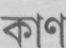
কাণ
